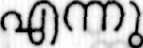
എന്നു
